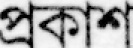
প্রকাশ
